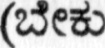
(ಬೇಕು
